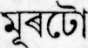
মূৰটো
